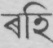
ৰহি
